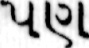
પણ
